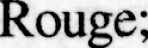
Rouge;
